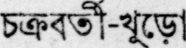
চক্রবর্তী-খুড়ো
